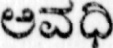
ಅವಧಿ
